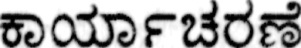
ಕಾರ್ಯಾಚರಣೆ
